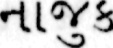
નાજુક
